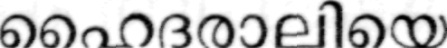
ഹൈദരാലിയെ
